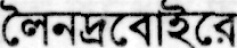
লৈনদ্রবোইরে
